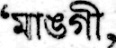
‘মাঙগী,
